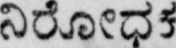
ನಿರೋಧಕ
